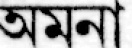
অমনা
